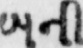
બની
